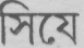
সিযে
